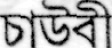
চাউবী
